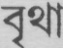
বৃথা
